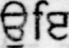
ਉਇ
